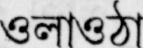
ওলাওঠা
